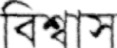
বিশ্বাস
